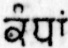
ਕੰਧਾਂ
